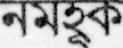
নমহূক
